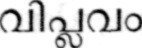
വിപ്ലവം
